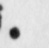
છે.
